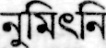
নুমিৎনি
